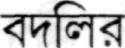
বদলির
